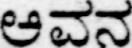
ಅವನ
